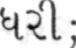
ધરી
